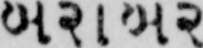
બરાબર
